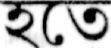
হতে
